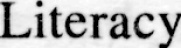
Literacy
